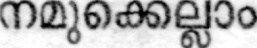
നമുക്കെല്ലാം
